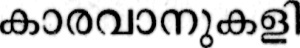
കാരവാനുകളി
